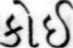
કોઈ
